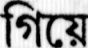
গিয়ে
